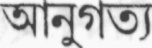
আনুগত্য
